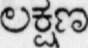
ಲಕ್ಷಣ
